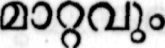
മാറ്റവും
